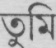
তুমি
